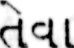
તેવા
